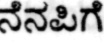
ನೆನಪಿಗೆ
